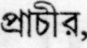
প্রাচীর,
